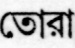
তোরা
